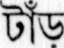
টাঁড়
